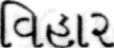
વિહાર
